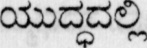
ಯುದ್ಧದಲ್ಲಿ
